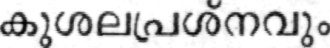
കുശലപ്രശ്നവും
